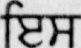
ਇਸ
